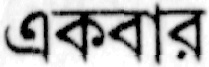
একবার
